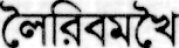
লৈরিবমখৈ
